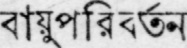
বায়ুপরিবর্তন
